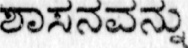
ಶಾಸನವನ್ನು
